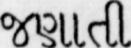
જણાતી
